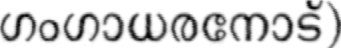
ഗംഗാധരനോട്)
